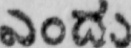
ಎಂದು
